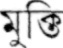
মুক্তি
